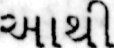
આથી
